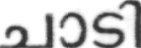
ചാടി
